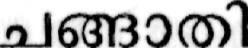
ചങ്ങാതി
